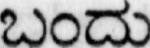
ಬಂದು
